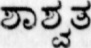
ಶಾಶ್ವತ
